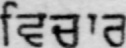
ਵਿਚਾਰ
